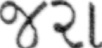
જરા
